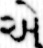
એ
